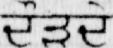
ਦੌੜਦੇ
